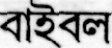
বাইবল
